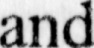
and
